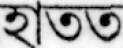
হাতত
